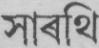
সাৰথি
